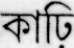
কাঢ়ি
